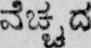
ವೆಚ್ಚದ
